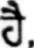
ਹੈ,
